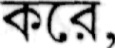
করে,
